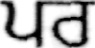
ਪਰ
